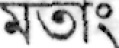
মতাং
